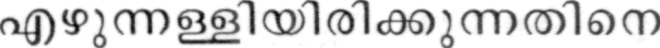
എഴുന്നള്ളിയിരിക്കുന്നതിനെ
